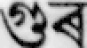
গুৰ
